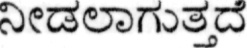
ನೀಡಲಾಗುತ್ತದೆ
